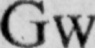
Gw
